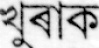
খুৰাক
